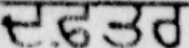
ਦਫ਼ਤਰ
